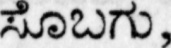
ಸೊಬಗು,
